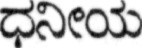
ಧನೀಯ
